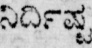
ನಿರ್ದಿಷ್ಟ
